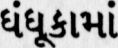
ધંધૂકામાં
